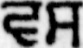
ਵਸ
